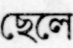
ছেলে
